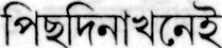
পিছদিনাখনেই
